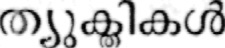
ത്യുക്തികള്‍
